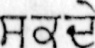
ਸਕਦੇ
